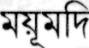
ময়ূমদি
